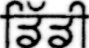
ਡਿੱਡੀ
